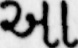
આ
